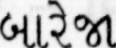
બારેજા
